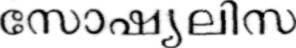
സോഷ്യലിസ
